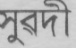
সুৱদী
